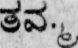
ತಮ್ಮ
